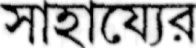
সাহায্যের
